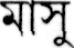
মাসু
